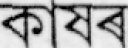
কাষৰ
